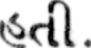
હતી.
